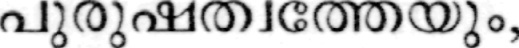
പുരുഷത്വത്തേയും,
